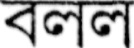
বলল
